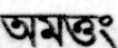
অমত্তং
